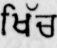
ਖਿੱਚ
